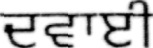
ਦਵਾਈ
